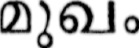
മുഖം
